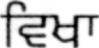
ਵਿਖਾ
